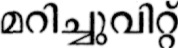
മിറച്ചുവിറ്റ്
